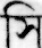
সি
